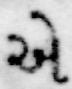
એ
